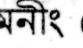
মনীং
